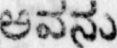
ಅವನು
